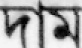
দাম
